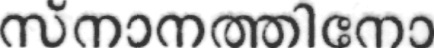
സ്നാനത്തിനോ
